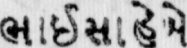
ભાઈસાહેબે
